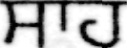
ਸਾਹ
